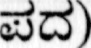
ಪದ)
